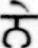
ਨੇ
